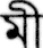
মী
